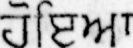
ਹੋਇਆ
